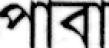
পাবা
